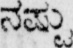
ನಷ್ಟು
